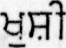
ਖੁਸ਼ੀ
